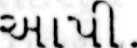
આપી.
